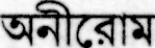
অনীরোম
